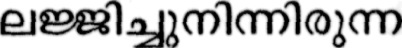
ലജ്ജിച്ചുനിന്നിരുന്ന
